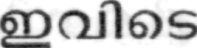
ഇവിടെ
